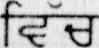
ਵਿੱਚ
